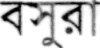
বসুরা
